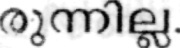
രുന്നില്ല.
